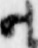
ન
